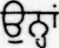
ਉਨ੍ਹਾਂ
